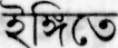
ইঙ্গিতে
